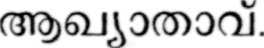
ആഖ്യാതാവ്.
